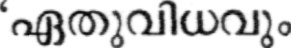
‘ഏതുവിധവും
